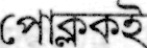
পোক্লকই
